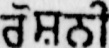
ਰੋਸ਼ਨੀ
